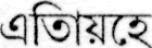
এতিায়হে
